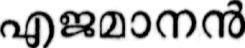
എജമാനന്‍
